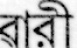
ৱারী
